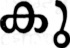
കു
